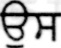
ਉਸ
